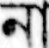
না
